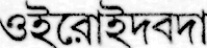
ওইরোইদবদা
